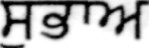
ਸੁਭਾਅ
